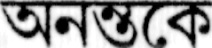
অনন্তকে
